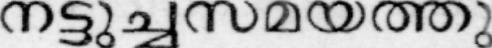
നട്ടുച്ചസമയത്തു
